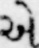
એ
